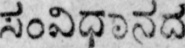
ಸಂವಿಧಾನದ
